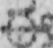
ಈ
